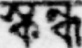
স্কন্ধ
